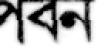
পবন
